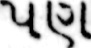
પણ
